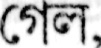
গেল,
